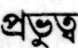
প্রভুত্ব
